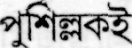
পুশিল্লকই
